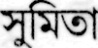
সুমিতা
